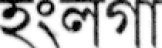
হংলগা
